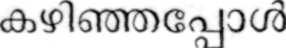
കഴിഞ്ഞപ്പോള്‍
